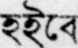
হইবে
